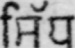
ਸਿੱਧ
